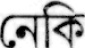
নেকি
